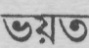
ভয়ত
